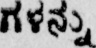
ಗಳನ್ನು
